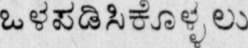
ಒಳಪಡಿಸಿಕೊಳ್ಳಲು
